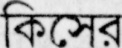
কিসের
